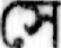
সে
